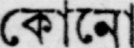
কোনো
